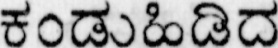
ಕಂಡುಹಿಡಿದ
